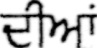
ਦੀਆਂ
